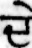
ਦੇ
